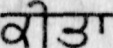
ਕੀਤਾ
